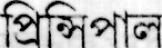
প্রিন্সিপাল
